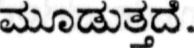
ಮೂಡುತ್ತದೆ.
